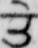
ਤੇ
